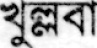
খুল্লবা
